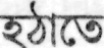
হঠাতে
